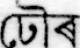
ঢৌৰ
